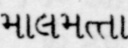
માલમત્તા
